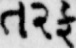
તરફ
